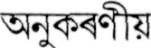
অনুকৰণীয়
